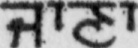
ਜਾਣਾ
